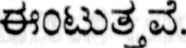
ಈಂಟುತ್ತವೆ.
